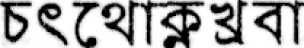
চৎথোক্নখ্রবা
